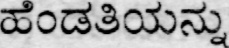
ಹೆಂಡತಿಯನ್ನು
